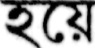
হয়ে
